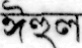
ঈহুল
